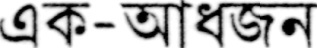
এক-আধজন
